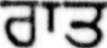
ਰਾਤ
